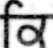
ਕਿ
